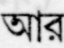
আর
